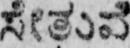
ಸೇತುವೆ
